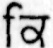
ਕਿ
